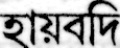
হায়বদি
